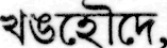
খঙহৌদে,
